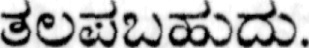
ತಲಪಬಹುದು.
